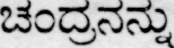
ಚಂದ್ರನನ್ನು
